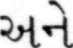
અને
